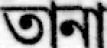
তানা
